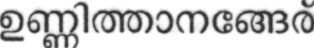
ഉണ്ണിത്താനങ്ങേര്
